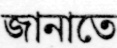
জানাতে
